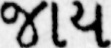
જાય
